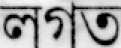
লগত
